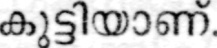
കുട്ടിയാണ്.
